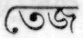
তেজ
